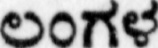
ಲಂಗಳ
